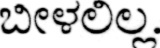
ಬೀಳಲಿಲ್ಲ.
